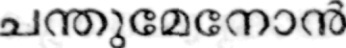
ചന്തുമേനോന്‍
